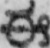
ಈ
